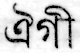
ঐগী
